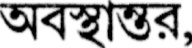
অবস্থান্তর,
